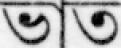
ভাত
